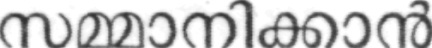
സമ്മാനിക്കാന്‍
